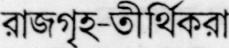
রাজগৃহ-তীর্থিকরা
